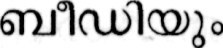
ബീഡിയും
